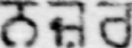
ਨਜ਼ਰ
